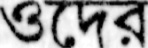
ওদের
